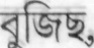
বুজিছ,
